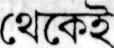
থেকেই
